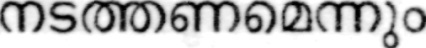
നടത്തണമെന്നും
